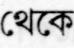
থেকে
